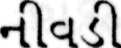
નીવડી
